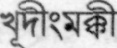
খূদীংমক্কী
